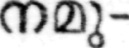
നമു-
